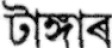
টাঙ্গাৰ
